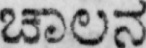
ಚಾಲನ
